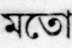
মতো
